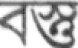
বস্তু
